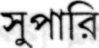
সুপারি
